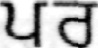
ਪਰ
